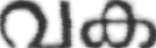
വക
